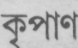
কৃপাণ
